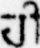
ਹੀ
